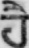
ਹੈ
